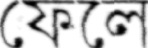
ফেলে
